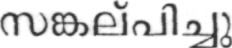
സങ്കല്പിച്ചു
